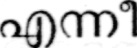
എന്നീ
